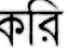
করি
